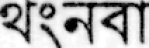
থংনবা
